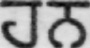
ਹਨ
